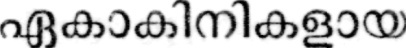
ഏകാകിനികളായ
